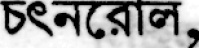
চৎনরোল,
